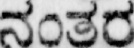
ನಂತರ
